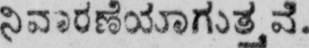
ನಿವಾರಣೆಯಾಗುತ್ತವೆ.
